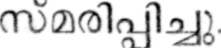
സ്മരിപ്പിച്ചു.
